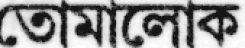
তোমালোক
